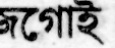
জগোই
